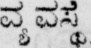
ವ್ಯವಸ್ಥೆ
